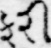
ફરી
